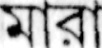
মারা
